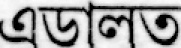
এডালত
